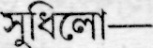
সুধিলো-
